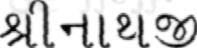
શ્રીનાથજી
